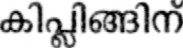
കിപ്ലിങ്ങിന്
